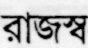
রাজস্ব
